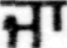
ਜਾ
